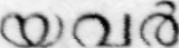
യവര്‍
